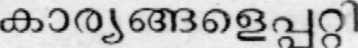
കാര്യങ്ങളെപ്പറ്റി
